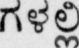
ಗಳಲ್ಲಿ
